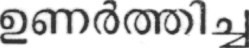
ഉണര്‍ത്തിച്ച
